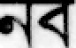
নব
